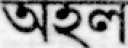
অহল
